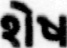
શેષ
